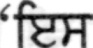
'ਇਸ
